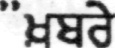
''ਖ਼ਬਰੇ
